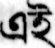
এই
